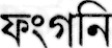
ফংগনি
